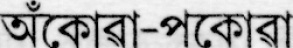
অঁকোৱা-পকোৱা
